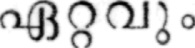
ഏറ്റവും
